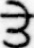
ਤੇ
